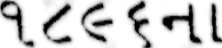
૧૮૯૬ના
